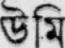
উমি
